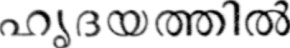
ഹൃദയത്തില്‍
